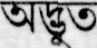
অদ্ভুত
